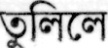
তুলিলে
